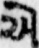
એ
